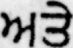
ਅਤੇ
